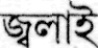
জ্বলাই
